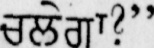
ਚਲੇਗਾ?''
